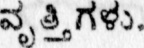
ವೃತ್ತಿಗಳು,
